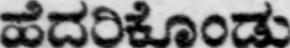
ಹೆದರಿಕೊಂಡು
